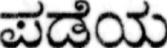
ಪಡೆಯ
